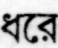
ধরে
